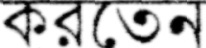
করতেন
